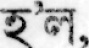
হ'ল,
